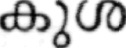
കുശ
